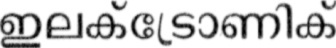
ഇലക്ട്രോണിക്
